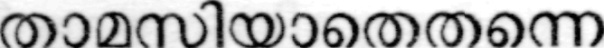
താമസിയാതെതന്നെ
